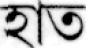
হাত
